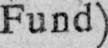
Fund)
